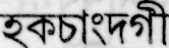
হকচাংদগী
